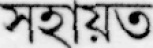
সহায়ত
